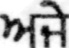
ਅਜੇ
